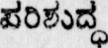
ಪರಿಶುದ್ಧ
